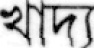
খাদ্য
